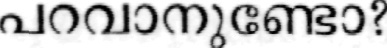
പറവാനുണ്ടോ?
